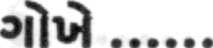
ગોખે.......
